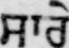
ਸਾਰੇ
